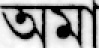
অমা
